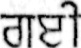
ਗਈ
